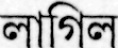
লাগিল
